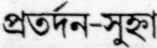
প্রতর্দন-সুহ্না
